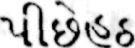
પીછેહઠ
